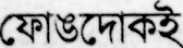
ফোঙদোকই
